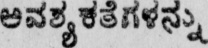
ಅವಶ್ಯಕತೆಗಳನ್ನು
